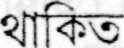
থাকিত
